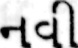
નવી
